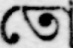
তো
